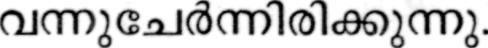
വന്നുചേര്‍ന്നിരിക്കുന്നു.
